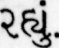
રહ્યું.
